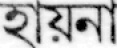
হায়না
